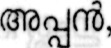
അപ്പന്‍,
